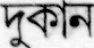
দুকান
